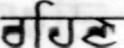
ਰਹਿਣ
